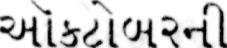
ઑક્ટોબરની
